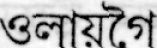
ওলায়গৈ
